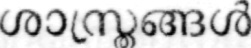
ശാസ്ത്രങ്ങള്‍
